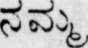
ನಮ್ಮ
